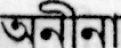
অনীনা
